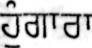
ਹੁੰਗਾਰਾ
